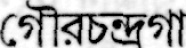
গৌরচন্দ্রগা
